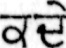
ਕਦੇ
